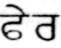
ਫੇਰ
